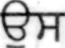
ਉਸ
